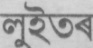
লুইতৰ
